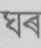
ঘৰ
